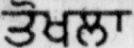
ਤੋਖਲਾ
